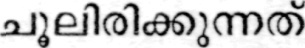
ചൂലിരിക്കുന്നത്
